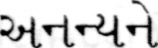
અનન્યને
